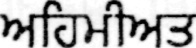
ਅਹਿਮੀਅਤ
